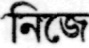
নিজে
